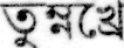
তুম্নখ্রে
